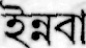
ইন্নবা
